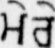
ਮੇਰੇ
